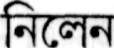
নিলেন
